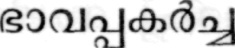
ഭാവപ്പകര്‍ച്ച
